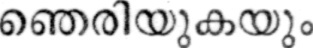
ഞെരിയുകയും
